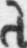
તે
